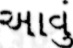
આવું
